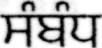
ਸੰਬੰਧ
